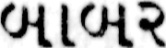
બાબર
